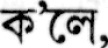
ক'লে,
